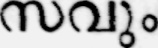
സവും
